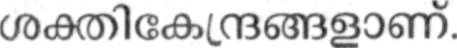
ശക്തികേന്ദ്രങ്ങളാണ്.
